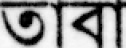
তাবা
